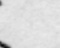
પુત્ર
